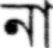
না
